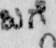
ಬಗ್ಗೆ
